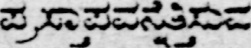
ಪ್ರಸ್ತಾಪವನೆತ್ತೆಸುವ
